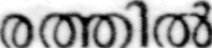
രത്തില്‍
